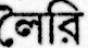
লৈরি
